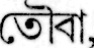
তৌবা,
